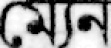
ম্যেন
